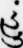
હું
